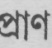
প্ৰাণ
